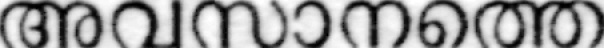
അവസാനത്തെ
